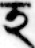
হ
